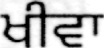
ਖੀਵਾ
